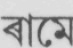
ৰামে
